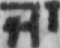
ਜਾ
